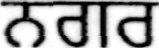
ਨਗਰ
